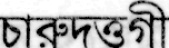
চারুদত্তগী
